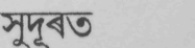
সুদূৰত
